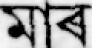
মাৰ
